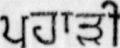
ਪਹਾੜੀ
